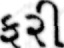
ફરી
